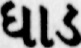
ધાડ
